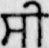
ਸੀ
